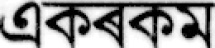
একৰকম
